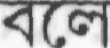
বলে
